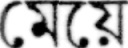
মেয়ে
